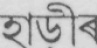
হাড়ীৰ
